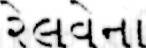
રેલવેના
